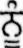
ਨੂੰ
